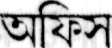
অফিস
